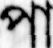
পা
